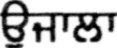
ਉਜਾਲਾ
